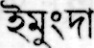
ইমুংদা
